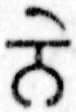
ਨੇ
